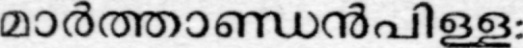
മാര്‍ത്താണ്ഡന്‍പിള്ള:
